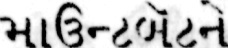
માઉન્ટબૅટને
